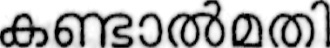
കണ്ടാല്‍മതി
